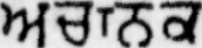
ਅਚਾਨਕ
